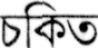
চকিত
